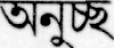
অনুচছ
